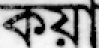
কয়া
